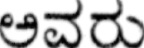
ಅವರು
